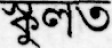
স্কুলত
